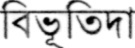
বিভূতিদা
